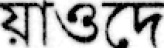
য়াওদে
